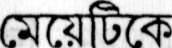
মেয়েটিকে
